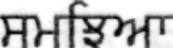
ਸਮਝਿਆ
